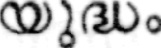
യുദ്ധം
